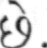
છે.
